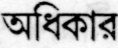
অধিকার
